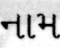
નામ
